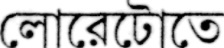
লোরেটোতে
